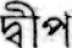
দ্বীপ
